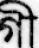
গী
